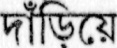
দাঁড়িয়ে
